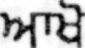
ਆਖੋ
